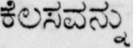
ಕೆಲಸವನ್ನು
